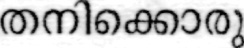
തനിക്കൊരു
